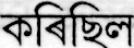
কৰিছিল
